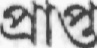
প্রাপ্ত
